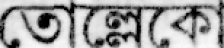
তোল্লেকো
